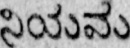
ನಿಯಮ
